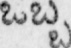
ಒಬ್ಬ
